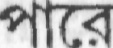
পারে
